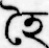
হৈ
